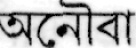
অনৌবা
